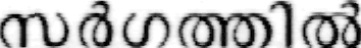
സര്‍ഗത്തില്‍
